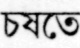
চষতে
